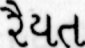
રૈયત
